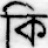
কি
